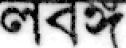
লবঙ্গ
